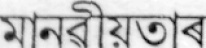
মানৱীয়তাৰ
